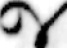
જ
